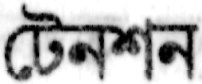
টেনশন
